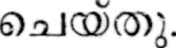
ചെയ്തു.
